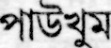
পাউখুম
